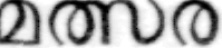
മത്സര
